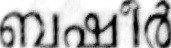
ബഷീര്‍
